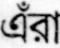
এঁরা
